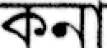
কনা
